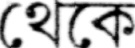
থেকে
